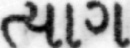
ત્યાગ
